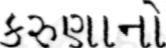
કરુણાનો
